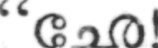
"ഛേ!
